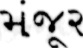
મંજૂર
